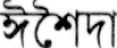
ঈশৈদা
